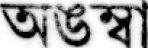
অঙম্বা
